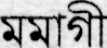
মমাগী
